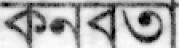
কনবতা
